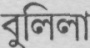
বুলিলা
